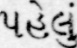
પહેલું
